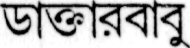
ডাক্তারবাবু
